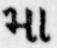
મા
